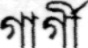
গার্গী
